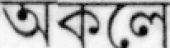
অকলে
